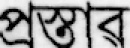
প্রস্তাৱ
